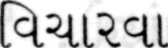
વિચારવા
